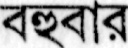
বহুবার
